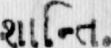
શાન્તિ.
